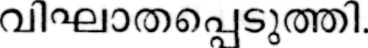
വിഘാതപ്പെടുത്തി.
